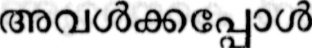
അവള്‍ക്കപ്പോള്‍
